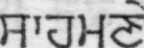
ਸਾਹਮਣੇ
